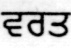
ਵਰਤ
